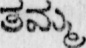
ತಮ್ಮ
